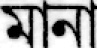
মানা
